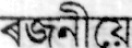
ৰজনীয়ে
